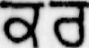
ਕਰ
